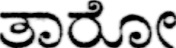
ತಾರೋ
